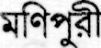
মণিপুরী
